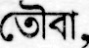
তৌবা,
